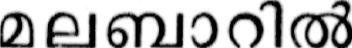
മലബാറില്‍
